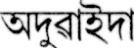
অদুৱাইদা
